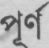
পূৰ্ণ
